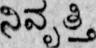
ನಿವೃತ್ತಿ
